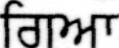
ਗਿਆ
